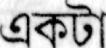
একটা
